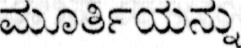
ಮೂರ್ತಿಯನ್ನು
